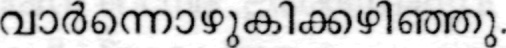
വാര്‍ന്നൊഴുകിക്കഴിഞ്ഞു.
